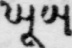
ખૂબ
